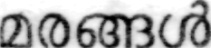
മരങ്ങള്‍
